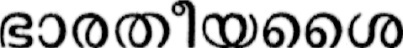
ഭാരതീയശൈ
